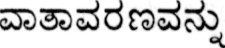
ವಾತಾವರಣವನ್ನು
